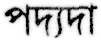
পদ্যদা
